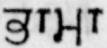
ਭਾਮਾ
